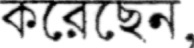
করেছেন,
